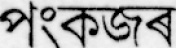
পংকজৰ
